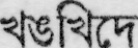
খঙখিদে
